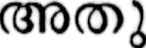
അതു
